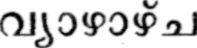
വ്യാഴാഴ്ച
